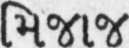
મિજાજ
